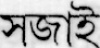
সজাই
